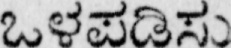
ಒಳಪಡಿಸು
